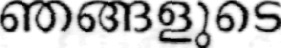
ഞങ്ങളുടെ
